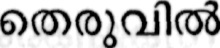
തെരുവില്‍
